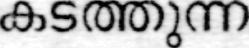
കടത്തുന്ന
